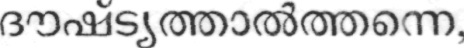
ദൗഷ്ട്യത്താല്‍ത്തന്നെ,
